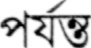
পর্যন্ত
